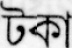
টকা
